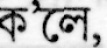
ক'লে,
